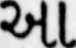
આ
